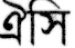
ঐসি
